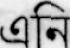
এনি
